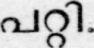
പറ്റി.
